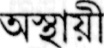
অস্থায়ী
